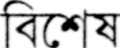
বিশেষ
